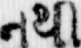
નથી
